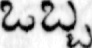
ಒಬ್ಬ
